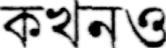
কখনও
